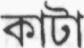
কাটা
